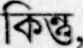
কিন্তু,
